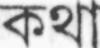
কথা
